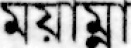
ময়াম্না
